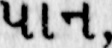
પાન,
